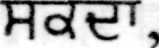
ਸਕਦਾ,
